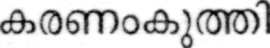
കരണംകുത്തി
